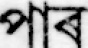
পাৰ
